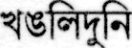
খঙলিদুনি
